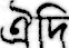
ঐদি
